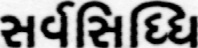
સર્વસિધ્ધિ
